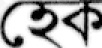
হেক
